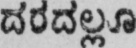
ದರದಲ್ಲೂ
